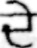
ਦੇ
